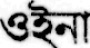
ওইনা
